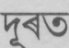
দূৰত
